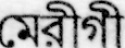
মেরীগী
